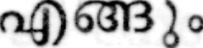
എങ്ങും
